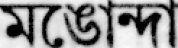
মঙোন্দা
